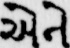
એને
